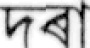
দৰা
